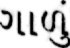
ગાળું
